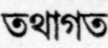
তথাগত
